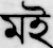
মই
